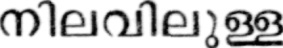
നിലവിലുള്ള
